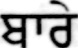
ਬਾਰੇ
